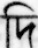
দি
